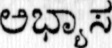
ಅಭ್ಯಾಸ
